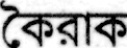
কৈরাক
